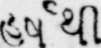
હર્ષથી
